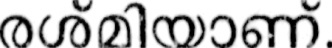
രശ്മിയാണ്.
